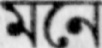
মনে
